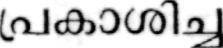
പ്രകാശിച്ച
